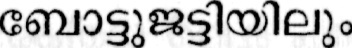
ബോട്ടുജട്ടിയിലും
